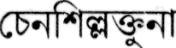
চেনশল্লক্তুনা
